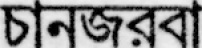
চানজরবা
